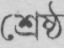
শ্ৰেষ্ঠ
